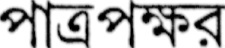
পাত্রপক্ষর
